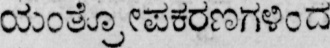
ಯಂತ್ರೋಪಕರಣಗಳಿಂದ
